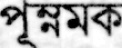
পূম্নমক
